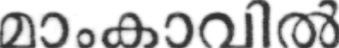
മാംകാവില്‍
